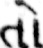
તો
